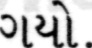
ગયો.
